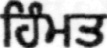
ਹਿੰਮਤ
